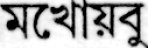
মখোয়বু
